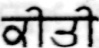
ਕੀਤੀ
